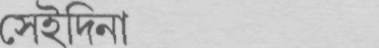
সেইদিনা
